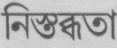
নিস্তব্ধতা
